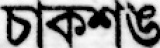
চাকশঙ
